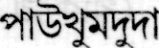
পাউখুমদুদা
